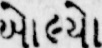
બોલ્યો
